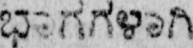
ಭಾಗಗಳಾಗಿ
